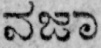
ವಜಾ
